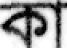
কা
